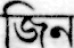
জিন
